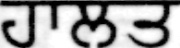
ਹਾਲਤ
